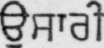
ਉਸਾਰੀ
